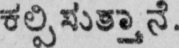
ಕಲ್ಪಿಸುತ್ತಾನೆ.
